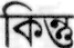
কিন্তু
